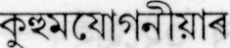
কুহুমযোগনীয়াৰ
